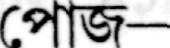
পোজ-
